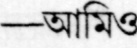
–আমিও
